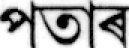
পতাৰ
